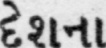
દેશના
